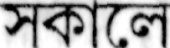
সকালে
